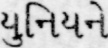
યુનિયને
